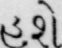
હશે
